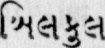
બિલકુલ
